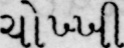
ચોખ્ખી
